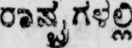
ರಾಷ್ಟ್ರಗಳಲ್ಲಿ
